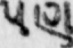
પણ
